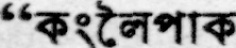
“কংলৈপাক
